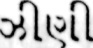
ઝીણી
